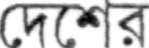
দেশের
